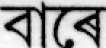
বাৰে
